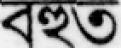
বহুত
